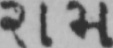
રામ
